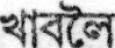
খাবলৈ
